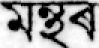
মন্থৰ
